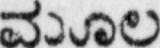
ಮೂಲ
